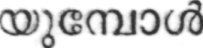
യുമ്പോള്‍
